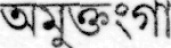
অমুক্তংগা
